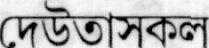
দেউতাসকল
